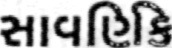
સાવર્ણિકે
